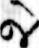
જે
